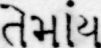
તેમાંય
